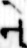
ને
